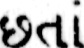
છતાં
